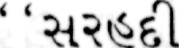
"સરહદી
